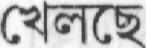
খেলছে
